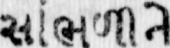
સાંભળીને
